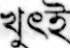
খুৎই
